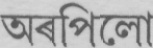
অৰপিলো
